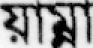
য়াম্না
